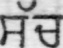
ਸੱਚ
